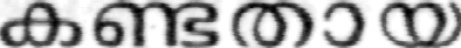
കണ്ടതായ
